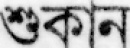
শুকান
